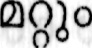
മറ്റും
